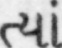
ત્યાં
